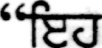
''ਇਹ
